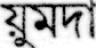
য়ুমদা
